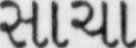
સાચા
